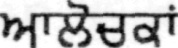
ਆਲੋਚਕਾਂ
